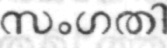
സംഗതി
